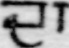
ਦਾ
